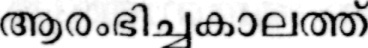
ആരംഭിച്ചകാലത്ത്
